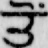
ਤੋਂ
